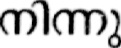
നിന്നു
